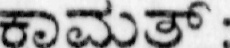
ಕಾಮತ್;
